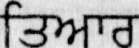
ਤਿਆਰ
